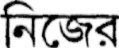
নিজের
